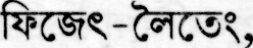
ফিজেৎ-লৈতেং,
